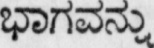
ಭಾಗವನ್ನು
